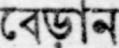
বেড়ান
